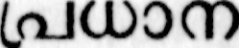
പ്രധാന
